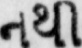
નથી
